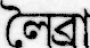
লৈব্রা
